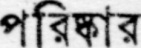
পরিষ্কার
